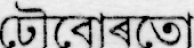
টোবোৰতো
